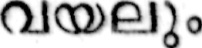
വയലും
